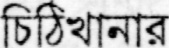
চিঠিখানার
